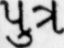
પુત્ર
